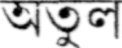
অতুল
